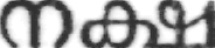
നക്ഷ
